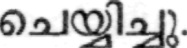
ചെയ്യിച്ചു.
